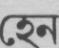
হেন
